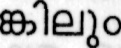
ങ്കിലും
